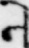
ને
